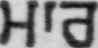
ਮਾਰ
